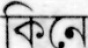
কিনে
